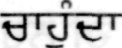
ਚਾਹੁੰਦਾ
